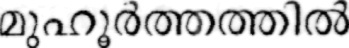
മുഹൂര്‍ത്തത്തില്‍
